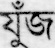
যুঁজ
